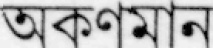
অকণমান
